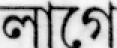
লাগে
